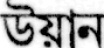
উয়ান
